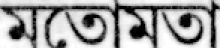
মতোমতা
